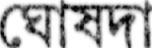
ঘোষদা
